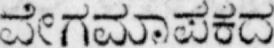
ವೇಗಮಾಪಕದ
